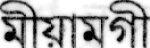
মীয়ামগী
